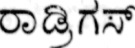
ರಾಡ್ರಿಗಸ್
